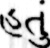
હતું
